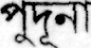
পুদূনা
